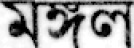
মঙ্গল
